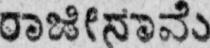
ರಾಜೀನಾಮೆ
